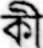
কী
